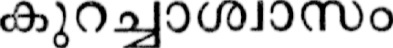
കുറച്ചാശ്വാസം
